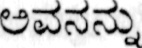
ಅವನನ್ನು
